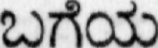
ಬಗೆಯ
